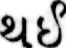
થઈ
